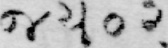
જય.૨
